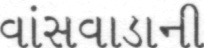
વાંસવાડાની
